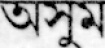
অসুম
